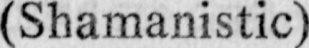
(Shamanistic)
